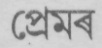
প্ৰেমৰ
